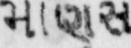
માણસ
